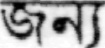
জন্য
